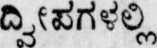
ದ್ವೀಪಗಳಲ್ಲಿ
